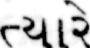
ત્યારે
